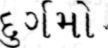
દુર્ગમો
